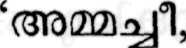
'അമ്മച്ചീ,
